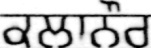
ਕਲਾਨੌਰ
